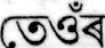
তেওঁৰ
